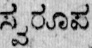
ಸ್ವರೂಪ
